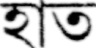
হাত
